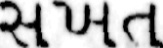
સખત
